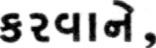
કરવાને,
